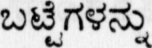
ಬಟ್ಟೆಗಳನ್ನು
